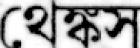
থেঙ্কস
